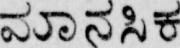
ಮಾನಸಿಕ
